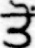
ਤੋਂ
